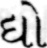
દ્યો
